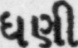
ધણી
